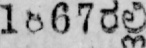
1867ರಲ್ಲಿ
